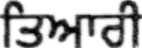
ਤਿਆਰੀ
